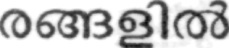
രങ്ങളില്‍
